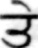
ਤੇ
